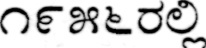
೧೯೫೬ರಲ್ಲಿ
